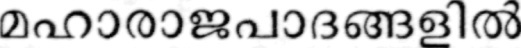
മഹാരാജപാദങ്ങളില്‍
